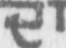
ਦਾ
